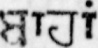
ਬਾਹਾਂ
